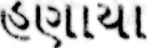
હણાયા
